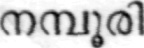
നമ്പൂരി
